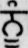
ਨੂੰ
